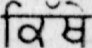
ਕਿੱਥੇ
